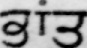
ਭਾਂਤ
